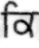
ਕਿ
